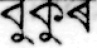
বুকুৰ
